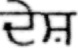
ਦੇਸ਼
